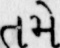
તમે
